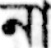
না
